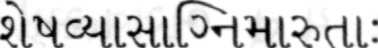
શેષવ્યાસાગનિમારતાઃ
